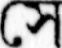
সে
